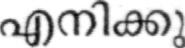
എനിക്കു
